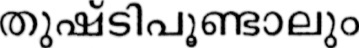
തുഷ്ടിപൂണ്ടാലും
